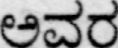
ಅವರ
